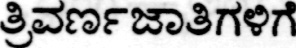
ತ್ರಿವರ್ಣಜಾತಿಗಳಿಗೆ
